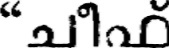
"ചീഫ്
